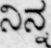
ನಿನ್ನ
